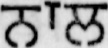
ਨਾਲ
